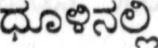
ಧೂಳಿನಲ್ಲಿ
